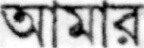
আমার
